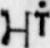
ਮਾਂ
